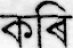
কৰি
